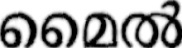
മൈല്‍
